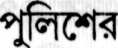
পুলিশের
